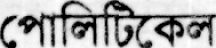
পোলিটিকেল
